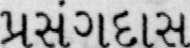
પ્રસંગદાસ
